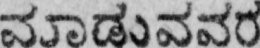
ಮಾಡುವವರ
